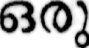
ഒരു
